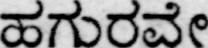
ಹಗುರವೇ
